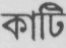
কাটি
